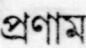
প্রণাম
